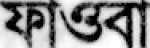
ফাওবা
